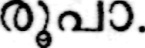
രൂപാ.
